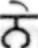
ਨੇ
